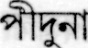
পীদুনা
